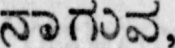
ನಾಗುವ,
